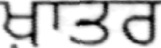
ਖ਼ਾਤਰ
